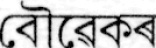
বৌৱেকৰ
